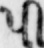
પી
